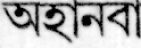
অহানবা
